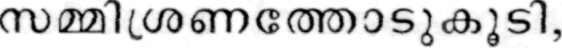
സമ്മിശ്രണത്തോടുകൂടി,
